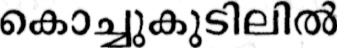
കൊച്ചുകുടിലില്‍
